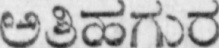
ಅತಿಹಗುರ
